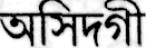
অসিদগী
